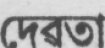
দেৱতা
